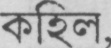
কহিল,
